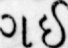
ગઈ
